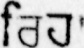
ਰਿਹਾ
